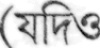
(যদিও
